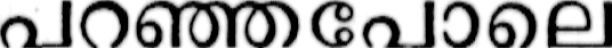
പറഞ്ഞപോലെ
